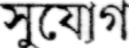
সুযোগ
